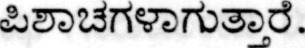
ಪಿಶಾಚಗಳಾಗುತ್ತಾರೆ.
